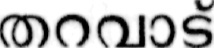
തറവാട്
